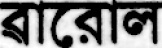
ৱারোল
